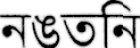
নঙতনি
